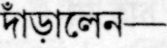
দাঁড়ালেন–
